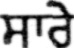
ਸਾਰੇ
